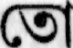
তো
